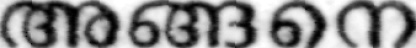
അങ്ങനെ
